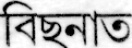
বিছনাত
